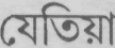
যেতিয়া
